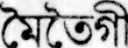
মৈতৈগী
